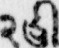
રહી
